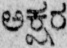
ಅಕ್ಷರ
